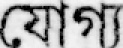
যোগ্য
